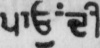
ਪਾਉਂਦੀ
